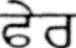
ਫੇਰ
